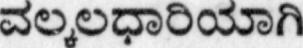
ವಲ್ಕಲಧಾರಿಯಾಗಿ
